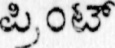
ಪ್ರಿಂಟ್
